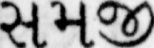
સમજી
